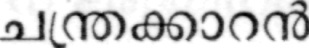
ചന്ത്രക്കാറന്‍
